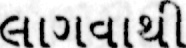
લાગવાથી
